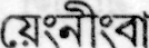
য়েংনীংবা
